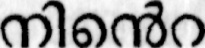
നിന്റെ
